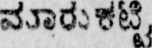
ಮಾರುಕಟ್ಟೆ
